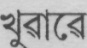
খুৱাৱে
